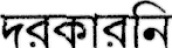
দরকারনি
